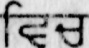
ਵਿਚ
